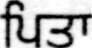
ਪਿਤਾ
